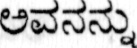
ಅವನನ್ನು
